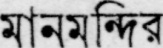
মানমন্দির
